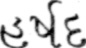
હર્ષદ
